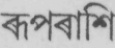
ৰূপৰাশি
